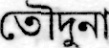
তৌদুনা
